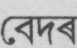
বেদৰ
